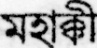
মহাক্কী
